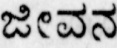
ಜೀವನ
